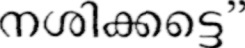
നശിക്കട്ടെ"
